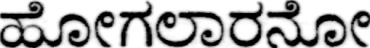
ಹೋಗಲಾರನೋ
